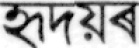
হৃদয়ৰ
